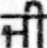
ਜੀ
